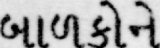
બાળકોને
